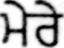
ਮੇਰੇ
